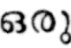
ഒരു
